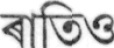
ৰাতিও
